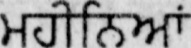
ਮਹੀਨਿਆਂ
